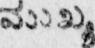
ಮುಖ್ಯ
